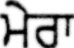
ਮੇਰਾ
